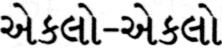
એકલો-એકલો
